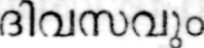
ദിവസവും
